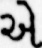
એ
